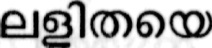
ലളിതയെ
